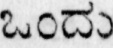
ಒಂದು
